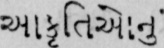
આકૃતિઓનું
